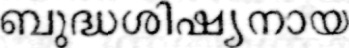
ബുദ്ധശിഷ്യനായ
